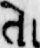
તો
